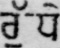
ਰੁੱਧੇ
